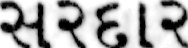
સરદાર
